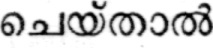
ചെയ്താല്‍
